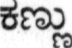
ಕಣ್ಣು
